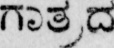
ಗಾತ್ರದ
